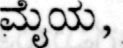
ಮೈಯ,
